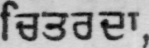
ਚਿਤਰਦਾ,
